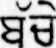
ਬੱਚੇ
